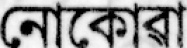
নোকোৱা
